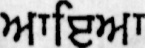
ਆਇਆ
